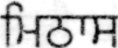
ਮਿਠਾਸ
